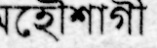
মহৌশাগী
